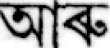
আৰু
